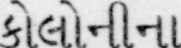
કોલોનીના
